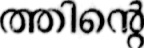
ത്തിന്റെ
